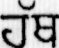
ਹੱਥ
